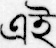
এই
